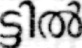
ട്ടില്‍
